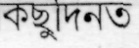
কিছুদিনত
